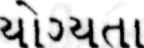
યોગ્યતા
